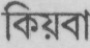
কিয়বা
